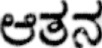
ಆತನ
